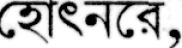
হোৎনরে,
